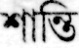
শান্তি
